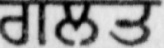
ਗਲਤ
